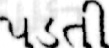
પડતી
